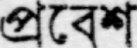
প্রবেশ
